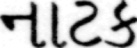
નાટક
